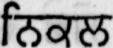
ਨਿਕਲ
